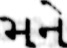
મને
